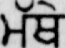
ਮੱਥੇ
